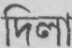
দিলা
